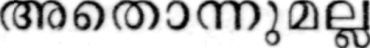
അതൊന്നുമല്ല
